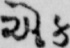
એક
